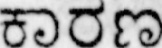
ಕಾರಣ
